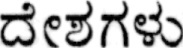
ದೇಶಗಳು
